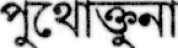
পুথোক্তুনা
